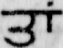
ਤਾਂ
